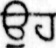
ਉਹ
